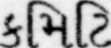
કમિટિ
